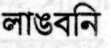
লাঙবনি
